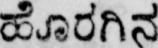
ಹೊರಗಿನ
